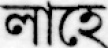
লাহে
